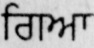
ਗਿਆ
